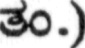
ತಂ.)
